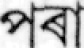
পৰা
